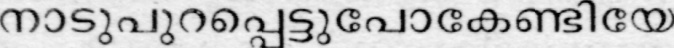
നാടുപുറപ്പെട്ടുപോകേണ്ടിയേ
